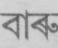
বাৰু
